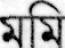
মমি
